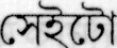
সেইটো
